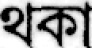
থকা
